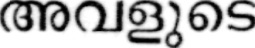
അവളുടെ
